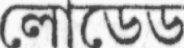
লোডেড
